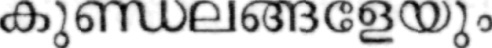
കുണ്ഡലങ്ങളേയും
